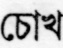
চোখ
